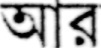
আর
